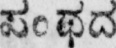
ಪಂಥದ
